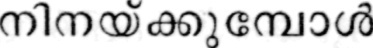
നിനയ്ക്കുമ്പോള്‍
